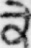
ਕੇ
